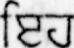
ਇਹ
